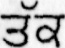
ਤੱਕ
